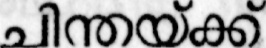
ചിന്തയ്ക്ക്
